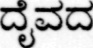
ದೈವದ
